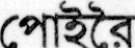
পোইরৈ
